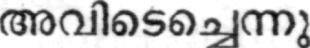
അവിടെച്ചെന്നു
